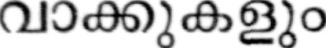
വാക്കുകളും
